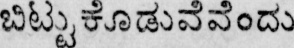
ಬಿಟ್ಟುಕೊಡುವೆವೆಂದು
